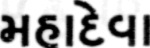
મહાદેવા
